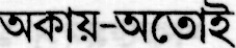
অকায়-অতোই
